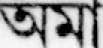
অমা
